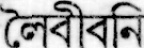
লৈবীবনি
